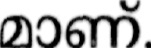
മാണ്.
